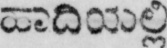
ಹಾದಿಯಲ್ಲಿ
